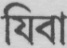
যিবা
